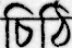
চিঠি
